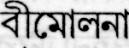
বীমোলনা
